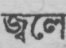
জ্বলে
